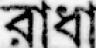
রাধা
